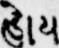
હોય
